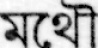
মথৌ
